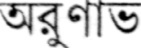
অরুণাভ
